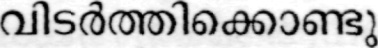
വിടര്‍ത്തിക്കൊണ്ടു
